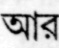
আর
